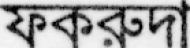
ফকরুদা
